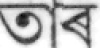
তাৰ
